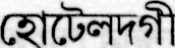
হোটেলদগী
